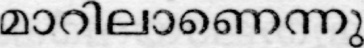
മാറിലാണെന്നു
